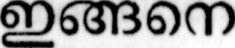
ഇങ്ങനെ
